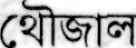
থৌজাল
